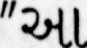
"આ
